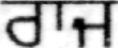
ਰਾਜ
